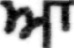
ਆ
